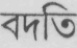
বদতি
